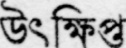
উৎক্ষিপ্ত
